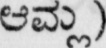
ಆಮ್ಲ)
